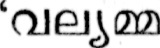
‘വല്യമ്മ
